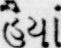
હૈયાં
